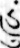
હું
